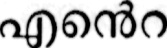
എന്റെ
